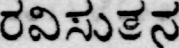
ರವಿಸುತನ
